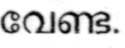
വേണ്ട.
